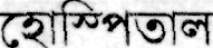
হোস্পিতাল
